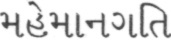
મહેમાનગતિ
